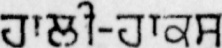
ਹਾਲੀ-ਹਾਕਸ
